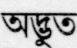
অদ্ভুত
